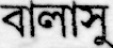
বালাসু
